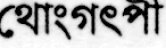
থোংগৎপী
